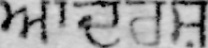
ਆਦਰਸ਼
